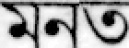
মনত
